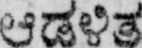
ಆಡಳಿತ
